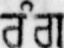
ਰੰਗ
